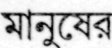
মানুষের
